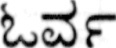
ಓರ್ವ
